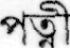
পত্নী
